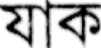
যাক
